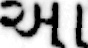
આ
